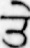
ਤੇ
